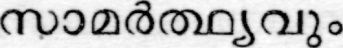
സാമര്‍ത്ഥ്യവും
